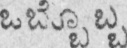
ಒಬ್ಬೊಬ್ಬ
